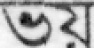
ভয়
